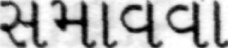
સમાવવા
